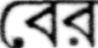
বের
